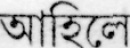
আহিলে
